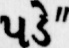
પડે"
